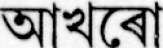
আখৰো
